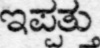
ಇಪ್ಪತ್ತು
